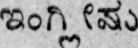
ಇಂಗ್ಲೀಷು
